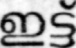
ഇട്ട്
